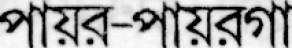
পায়র-পায়রগা
